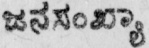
ಜನಸಂಖ್ಯಾ
